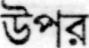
উপর
